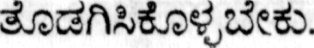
ತೊಡಗಿಸಿಕೊಳ್ಳಬೇಕು.
